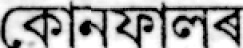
কোনফালৰ
